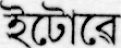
ইটোৱে
